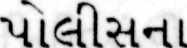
પોલીસના
